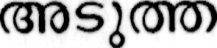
അടുത്ത
